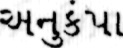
અનુકંપા
